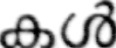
കള്‍
